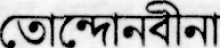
তোন্দোনবীনা
